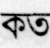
কত
